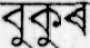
বুকুৰ
